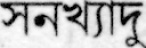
সনখ্যাদু
